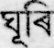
ঘূৰি
